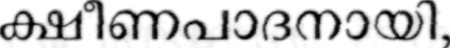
ക്ഷീണപാദനായി,
